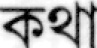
কথা
